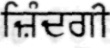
ਜ਼ਿੰਦਗੀ
